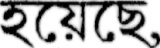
হয়েছে,
